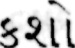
કશો
